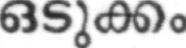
ഒടുക്കം
